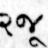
રજૂ
